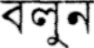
বলুন
